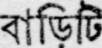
বাড়িটি
